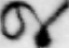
જ
